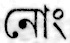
নোং
